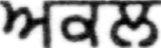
ਅਕਲ
